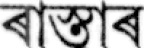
ৰাস্তাৰ
